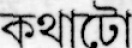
কথাটো
